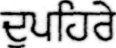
ਦੁਪਹਿਰੇ
